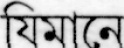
যিমানে
